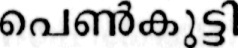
പെണ്‍കുട്ടി
